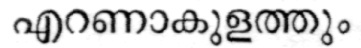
എറണാകുളത്തും
